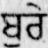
ਬੁਰੇ
